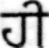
ਹੀ
